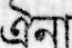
ঐনা
